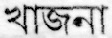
খাজনা
